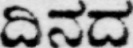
ದಿನದ
